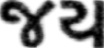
જય
